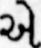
એ
